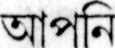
আপনি
